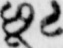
છૂટ
